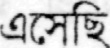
এসেছি
